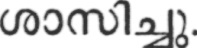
ശാസിച്ചു.
